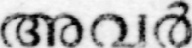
അവര്‍
